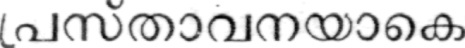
പ്രസ്താവനയാകെ
